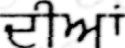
ਦੀਆਂ
